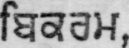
ਬਿਕਰਮ,
